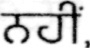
ਨਹੀਂ,
